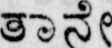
ತಾನೇ
